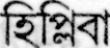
হিপ্লিবা
